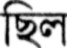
ছিল
